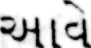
આવે
